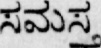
ಸಮಸ್ತ
